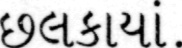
છલકાયાં.
